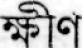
ক্ষীণ
